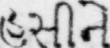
હસીને
